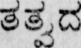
ತತ್ವದ
